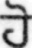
ਹੋ
